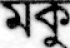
মকু
